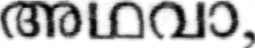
അഥവാ,
